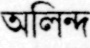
অলিন্দ
